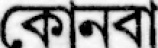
কোনবা
